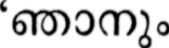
‘ഞാനും
